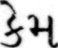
કેમ
